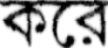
করে
